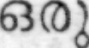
ഒരു
